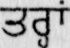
ਤਰ੍ਹਾਂ
